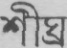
শীঘ্র
